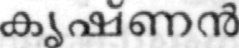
കൃഷ്ണന്‍
